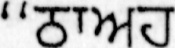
''ਠਾਅਹ
